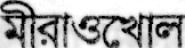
মীরাওখোল
